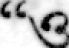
“ও
